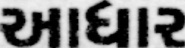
આધાર
